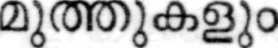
മുത്തുകളും
